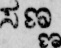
ಸಣ್ಣ
